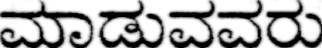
ಮಾಡುವವರು
